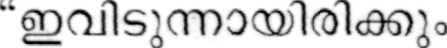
"ഇവിടുന്നായിരിക്കും
